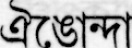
ঐঙোন্দা
